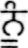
ਨੂੰ
